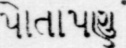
પોતાપણું
